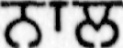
ਨਾਲ
